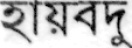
হায়বদু
